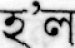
হ'ল
